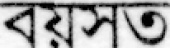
বয়সত
